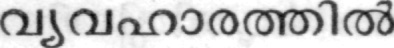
വ്യവഹാരത്തില്‍
